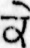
ਕੇ
